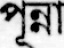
পূন্না
